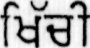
ਖਿੱਚੀ
